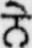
ਨੇ
